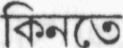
কিনতে
